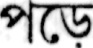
পড়ে
